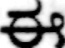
ಈ
